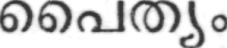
പൈത്യം
